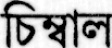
চিম্বাল
